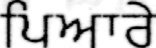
ਪਿਆਰੇ
